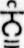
ਨੂੰ
